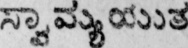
ಸ್ವಾಮ್ಯಯುತ
